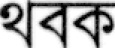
থবক
